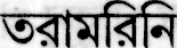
তরামরিনি
